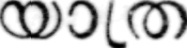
യാത്ര
